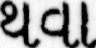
થવા
